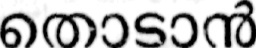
തൊടാന്‍
